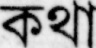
কথা
